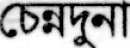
চেন্নদুনা
